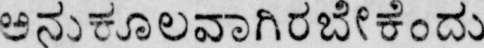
ಅನುಕೂಲವಾಗಿರಬೇಕೆಂದು
